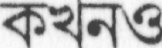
কখনও
